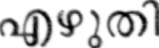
എഴുതി
